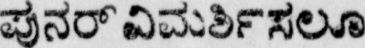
ಪುನರ್‌ವಿಮರ್ಶಿಸಲೂ
